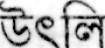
উৎলি
